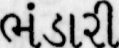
ભંડારી
